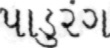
પાડુરંગ
